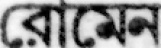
রোমেন
